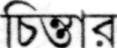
চিন্তার
